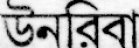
উনরিবা
